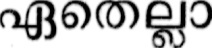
ഏതെല്ലാ
